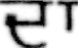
ਦਾ
